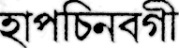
হাপচিনবগী
